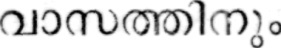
വാസത്തിനും
